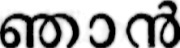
ഞാന്‍
